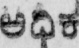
ಅಧಿಕ
